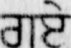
ਗਏ
